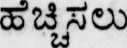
ಹೆಚ್ಚಿಸಲು
